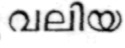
വലിയ
